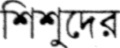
শিশুদের
